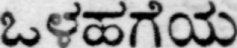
ಒಳಹಗೆಯ
